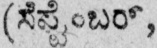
(ಸೆಪ್ಟೆಂಬರ್,
